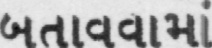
બતાવવામાં
